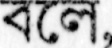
বলে,
